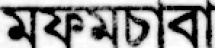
মফমচাবা
